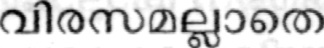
വിരസമല്ലാതെ
